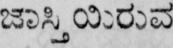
ಜಾಸ್ತಿಯಿರುವ
